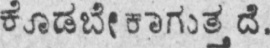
ಕೊಡಬೇಕಾಗುತ್ತದೆ.
